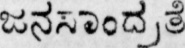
ಜನಸಾಂದ್ರತೆ
